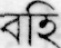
বহি
